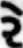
રે
